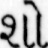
શો
